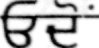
ਓਦੋਂ
